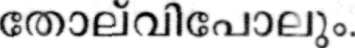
തോല്വിപോലും.
